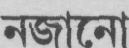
নজানো
